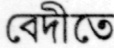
বেদীতে
